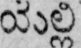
ಯಲ್ಲಿ
